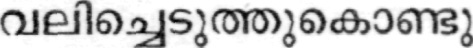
വലിച്ചെടുത്തുകൊണ്ടു
